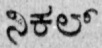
ನಿಕಲ್
